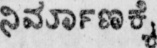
ನಿರ್ಮಾಣಕ್ಕೆ
